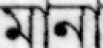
মানা
